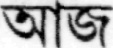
আজ
